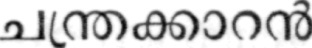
ചന്ത്രക്കാറന്‍
